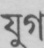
যুগ
